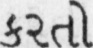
કરતો
